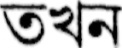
তখন
